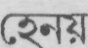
হেনয়
